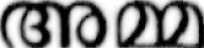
അമ്മ
